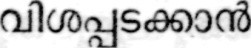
വിശപ്പടക്കാന്‍
